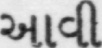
આવી
